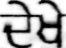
ਦੇਖੇ
